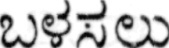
ಬಳಸಲು
